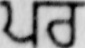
ਪਰ
